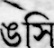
ঙসি
